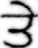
ਤੇ
